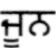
ਜੂਨ
